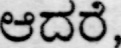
ಆದರೆ,
